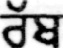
ਰੱਬ
